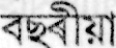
বছৰীয়া
